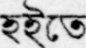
হইতে
